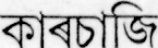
কাৰচাজি
